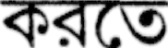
করতে
